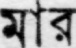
মার
